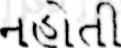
નહોતી
